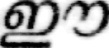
ഈ
